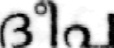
ദീപ
